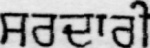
ਸਰਦਾਰੀ
